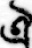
ঐ
